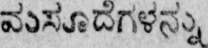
ಮಸೂದೆಗಳನ್ನು
